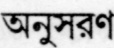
অনুসরণ
